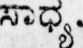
ಸಾಧ್ಯ.
